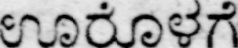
ಊರೊಳಗೆ
